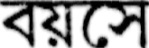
বয়সে
